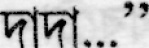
দাদা..."
